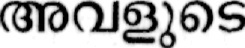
അവളുടെ
